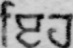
ਇਹ
